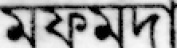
মফমদা
